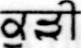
ਕੁੜੀ
